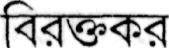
বিরক্তকর
